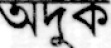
অদুক
